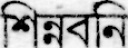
শিন্নবনি
